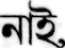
নাই,
